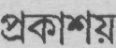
প্ৰকাশয়
